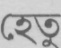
হেতু
